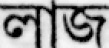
লাজ
